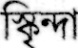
স্কিন্দা
